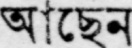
আছেন
